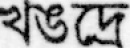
খঙদ্রে
